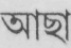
আছা
